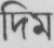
দিম
